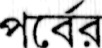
পর্বের
